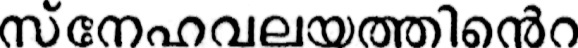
സ്നേഹവലയത്തിന്റെ
